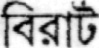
বিরাট
